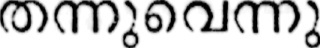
തന്നുവെന്നു
